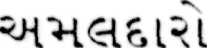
અમલદારો
